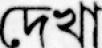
দেখা
